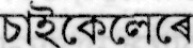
চাইকেলেৰে
